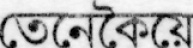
তেনেকৈয়ে
